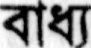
বাধ্য
